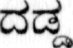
ದಡ್ಡ
